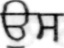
ਉਸ
